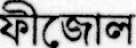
ফীজোল
